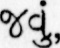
જવું,
